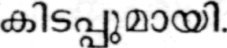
കിടപ്പുമായി.
